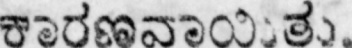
ಕಾರಣವಾಯಿತು.
